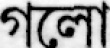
গলো
